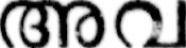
അവ
